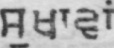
ਸੁਖਾਵਾਂ
